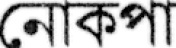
নোকপা
